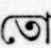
তো
